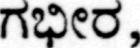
ಗಭೀರ,
